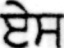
ਏਸ
